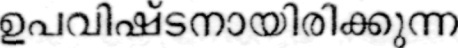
ഉപവിഷ്ടനായിരിക്കുന്ന
